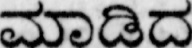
ಮಾಡಿದ
